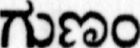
ಗುಣ೦
